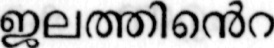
ജലത്തിന്റെൻെറ
